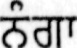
ਨੰਗਾ
